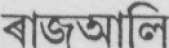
ৰাজআলি
